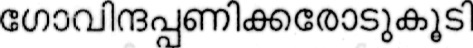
ഗോവിന്ദപ്പണിക്കരോടുകൂടി
